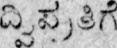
ದ್ವಿಪ್ರತಿಗೆ
